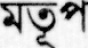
মতূপ
